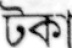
টকা
